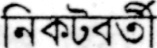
নিকটবর্তী
